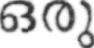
ഒരു
